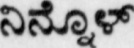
ನಿನ್ನೊಳ್
